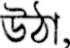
উঠা,
